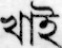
খাই
